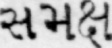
સમક્ષ
